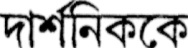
দার্শনিককে
